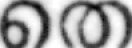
തെ
